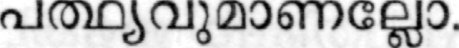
പത്ഥ്യവുമാണല്ലോ.
